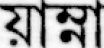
য়াম্না
